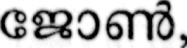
ജോണ്‍,
